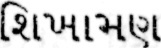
શિખામણ
